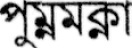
পুম্নমক্না
